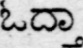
ಓದ್ತಾ
